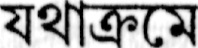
যথাক্রমে
